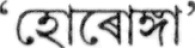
'হোৰোঙ্গা'
